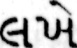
લખે
